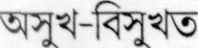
অসুখ-বিসুখত
